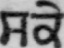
ਸਕੇ
